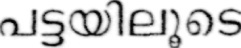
പട്ടയിലൂടെ
